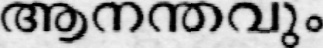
ആനന്തവും
